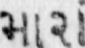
મારાં
